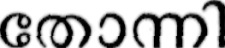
തോന്നി
